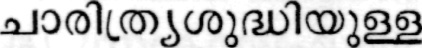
ചാരിത്ര്യശുദ്ധിയുള്ള
